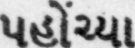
પહોંચ્યા
